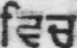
ਵਿਚ
